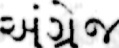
અંગ્રેજ
